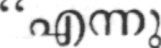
"എന്നു
